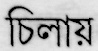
চিলায়
